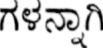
ಗಳನ್ನಾಗಿ
